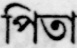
পিতা
